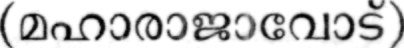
(മഹാരാജാവോട്)
